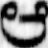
ಆ
